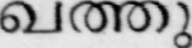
ഖത്തു
